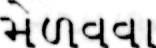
મેળવવા
